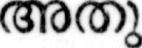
അതു
